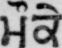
ਮੌਕੇ
